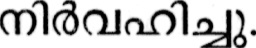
നിര്‍വഹിച്ചു.
